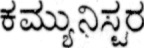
ಕಮ್ಯುನಿಸ್ಟರ
